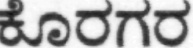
ಕೊರಗರ
